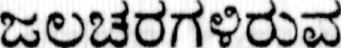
ಜಲಚರಗಳಿರುವ
